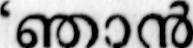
‘ഞാന്‍
